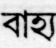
বাহ্য
